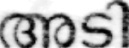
അടി
